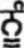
ਨੂੰ
